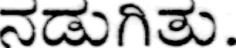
ನಡುಗಿತು.
